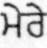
ਮੇਰੇ
